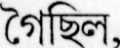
গৈছিল,
